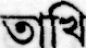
তাখি
